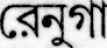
রেনুগা
